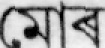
মোৰ
